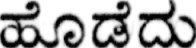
ಹೊಡೆದು
